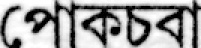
পোকচবা
